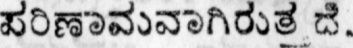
ಪರಿಣಾಮವಾಗಿರುತ್ತದೆ.
